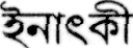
ইনাৎকী
